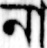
না
